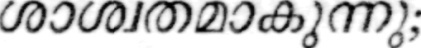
ശാശ്വതമാകുന്നു;
